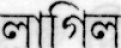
লাগিল
